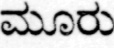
ಮೂರು
